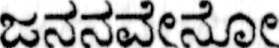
ಜನನವೇನೋ
